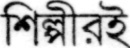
শিল্পীরই
